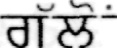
ਗੱਲੋਂ
